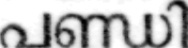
പണ്ഡി
